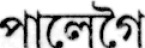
পালেগৈ
